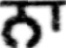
ਨਾ
